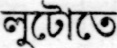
লুটোতে
